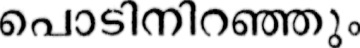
പൊടിനിറഞ്ഞും
